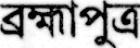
ব্রহ্মাপুত্র
